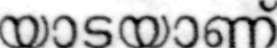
യാടയാണ്
